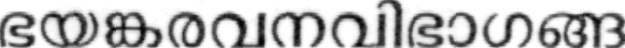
ഭയങ്കരവനവിഭാഗങ്ങ
